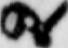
જ
